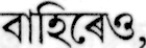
বাহিৰেও,
